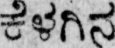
ಕೆಳಗಿನ
